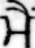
ਮੈਂ
